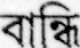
বান্ধি
